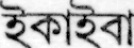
ইকাইবা
